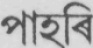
পাহৰি
